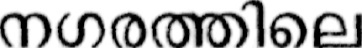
നഗരത്തിലെ
